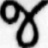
જ
